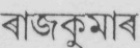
ৰাজকুমাৰ
